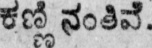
ಕಣ್ಣಿನಂತಿವೆ.
